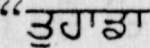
''ਤੁਹਾਡਾ
